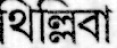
থিল্লিবা
